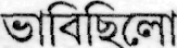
ভাবিছিলো
